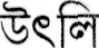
উৎলি
